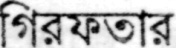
গিরফতার
